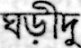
ঘড়ীদু
